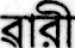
ৱারী
